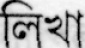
লিখা
